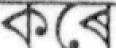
কৰে
